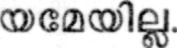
യമേയില്ല.
